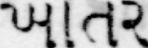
ખાતર
